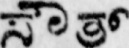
ಸೌತ್
